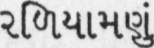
રળિયામણું
